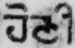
ਹੋਣੀ
